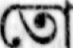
তো
